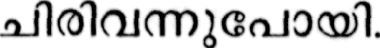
ചിരിവന്നുപോയി.
